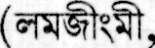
(লমজীংমী,
